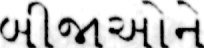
બીજાઓને
